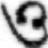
ও
